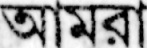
আমরা
